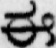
ಈ
